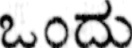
ಒಂದು
